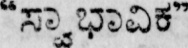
“ಸ್ವಾಭಾವಿಕ”
